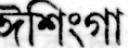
ঈশিংগা
